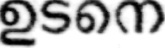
ഉടനെ
